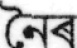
নৈৰ
